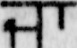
ਜਾ
